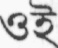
ওই
